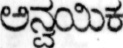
ಅನ್ವಯಿಕ
